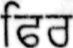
ਫਿਰ
